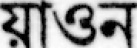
য়াওন
